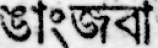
ঙাংজবা
